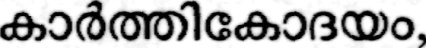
കാര്‍ത്തികോദയം,
